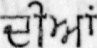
ਦੀਆਂ
